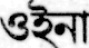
ওইনা
